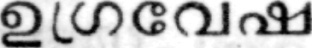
ഉഗ്രവേഷ
